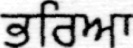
ਭਰਿਆ
